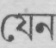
যেন
